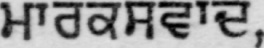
ਮਾਰਕਸਵਾਦ,
